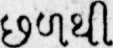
છળથી
